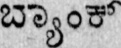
ಬ್ಯಾಂಕ್
